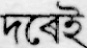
দৰেই
